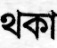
থকা
